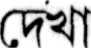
দেখা
